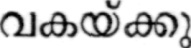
വകയ്ക്കു
